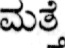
ಮತ್ತೆ
